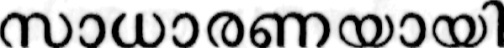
സാധാരണയായി
